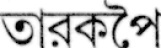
তারকপৈ
